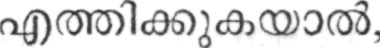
എത്തിക്കുകയാല്‍,
